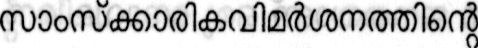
സാംസ്ക്കാരികവിമര്‍ശനത്തിന്റെ
